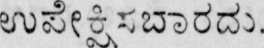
ಉಪೇಕ್ಷಿಸಬಾರದು.
